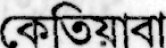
কেতিয়াবা
